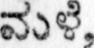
ಮಳೆ,
